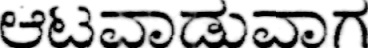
ಆಟವಾಡುವಾಗ
